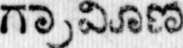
ಗ್ರಾಮೀಣ
